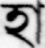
হা
